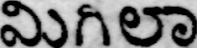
ಮಿಗಿಲಾ
